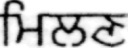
ਮਿਲਣ
